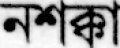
নশক্কা
